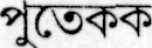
পুতেকক
